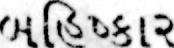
બહિષ્કાર
